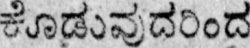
ಕೊಡುವುದರಿಂದ
